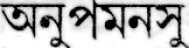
অনুপমনসু
